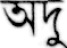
অদু
